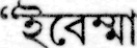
“ইবেম্মা
